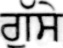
ਗੁੱਸੇ
